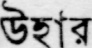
উহার
